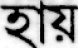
হায়
